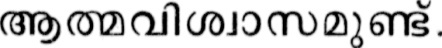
ആത്മവിശ്വാസമുണ്ട്.
